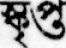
স্কৃপ্ত
